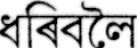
ধৰিবলৈ
